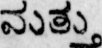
ಮತ್ತು
